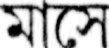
মাসে
